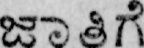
ಜಾತಿಗೆ
